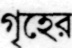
গৃহের
